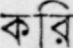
করি
